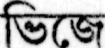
ভিজে
